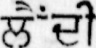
ਲੈਂਦੀ
